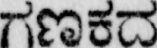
ಗಣಕದ
